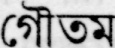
গৌতম
